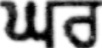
ਘਰ
